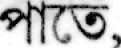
পাতে,
